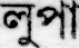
লুপা
